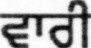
ਵਾਰੀ
